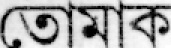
তোমাক
